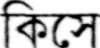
কিসে
